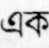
এক
